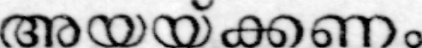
അയയ്ക്കണം
